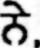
ਨੇ,
